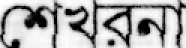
শেখরনা
